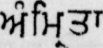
ਅੰਮ੍ਰਿਤਾ
